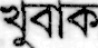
খুবাক
